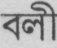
বলী
